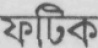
ফটিক
